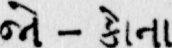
જો-કોના
